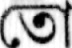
তো
